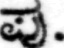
ಪು.
